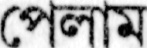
পেলাম
